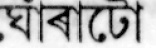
ঘোঁৰাটো
